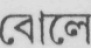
বোলে
